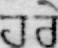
ਹਰੇ
